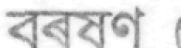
বৰষণ
